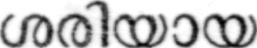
ശരിയായ
